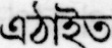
এঠাইত
